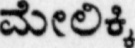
ಮೇಲಿಕ್ಕಿ
